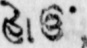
હોઉં,
